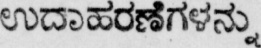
ಉದಾಹರಣೆಗಳನ್ನು
